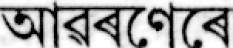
আৱৰণেৰে
